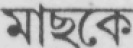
মাছকে
